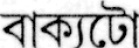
বাক্যটো
